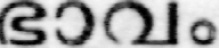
ഭാവം
